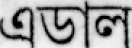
এডাল
